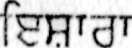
ਇਸ਼ਾਰਾ
